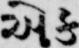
એક
